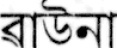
ৱাউনা
